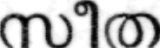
സീത
